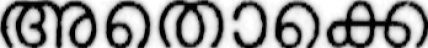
അതൊക്കെ
